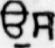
ਉਸ
